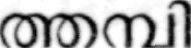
ത്തമ്പി
